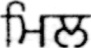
ਮਿਲ
